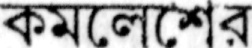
কমলেশের
